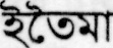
ইতৈমা
